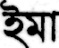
ইমা
